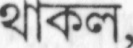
থাকল,
